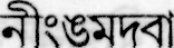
নীংঙমদবা
